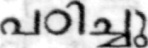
പഠിച്ചു
